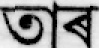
তাৰ
